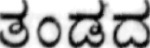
ತಂಡದ
